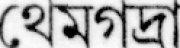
থেমগদ্রা
